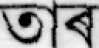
তাৰ
